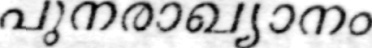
പുനരാഖ്യാനം
